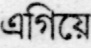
এগিয়ে
